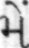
મેં
